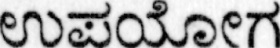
ಉಪಯೋಗ
